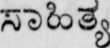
ಸಾಹಿತ್ಯ
